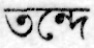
তন্দে
